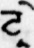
ਟ੍ਰੇ
